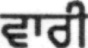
ਵਾਰੀ
